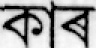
কাৰ
